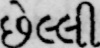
છેલ્લી
